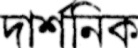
দার্শনিক
